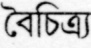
বৈচিত্র্য
